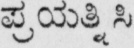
ಪ್ರಯತ್ನಿಸಿ
